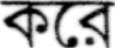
করে
